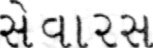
સેવારસ
